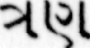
ત્રણ
